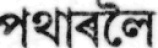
পথাৰলৈ
